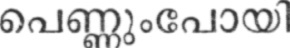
പെണ്ണുംപോയി
